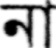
না
